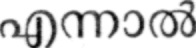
എന്നാല്‍
